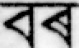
বৰ
